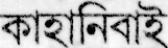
কাহানিবাই
